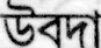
উবদা
